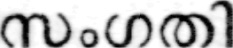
സംഗതി
